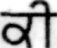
ਕੀ
